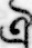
ঐ
